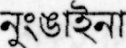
নুংঙাইনা
